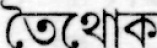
তৈথোক
